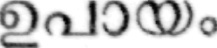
ഉപായം
